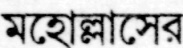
মহোল্লাসের
